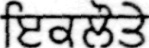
ਇਕਲੌਤੇ
